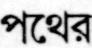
পথের
